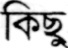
কিছু
